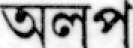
অলপ
